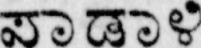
ಪಾಡಾಳಿ
